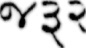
જરૂર
